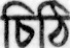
চিঠি
